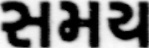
સમય
